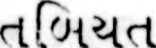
તબિયત
